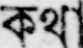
কথা
